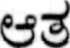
ಆತ
